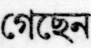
গেছেন
